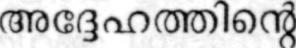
അദ്ദേഹത്തിന്റെ
